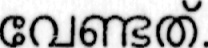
വേണ്ടത്.
